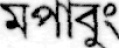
মপাবুং
